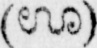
(ಊ)
